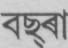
বছ্‌ৰা
